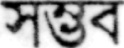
সম্ভব
